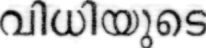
വിധിയുടെ
